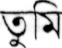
তুমি
